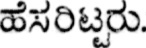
ಹೆಸರಿಟ್ಟರು.
